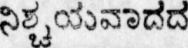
ನಿಶ್ಚಯವಾದದ
